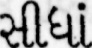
સીધાં
